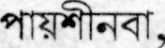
পায়শীনবা,
